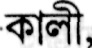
কালী,
